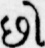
છો
